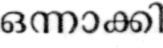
ഒന്നാക്കി
